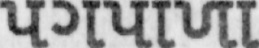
પગપાખા
